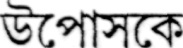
উপোসকে
